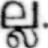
ല്ല.
